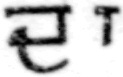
ਦਾ
